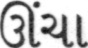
ઊંચા
